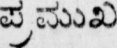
ಪ್ರಮುಖ
